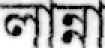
লান্না
